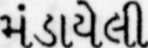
મંડાયેલી
